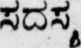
ಸದಸ್ಯ
